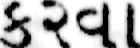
કરવા
